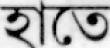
হাতে
